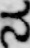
ನ
